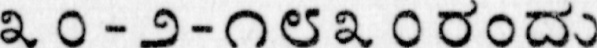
೩೦-೩-೧೮೩೦ರಂದು
